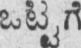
ಒಟ್ಟಿಗೆ
